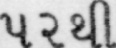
પરથી
